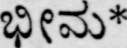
ಭೀಮ*
